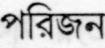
পরিজন
